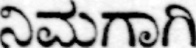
ನಿಮಗಾಗಿ
